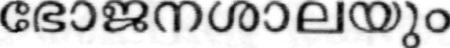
ഭോജനശാലയും
